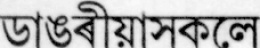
ডাঙৰীয়াসকলে
